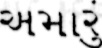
અમારું
